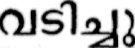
വടിച്ചു
